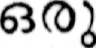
ഒരു
